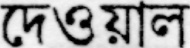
দেওয়াল
